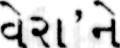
વેરા'ને
